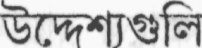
উদ্দেশ্যগুলি
